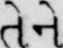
તેને
